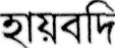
হায়বদি
